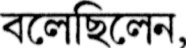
বলেছিলেন,
